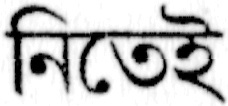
নিতেই
